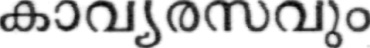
കാവ്യരസവും
